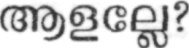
ആളല്ലേ?
